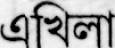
এখিলা
